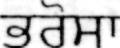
ਭਰੋਸਾ
